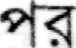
পর
